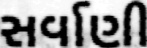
સર્વાણી
